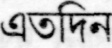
এতদিন
